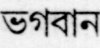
ভগবান
